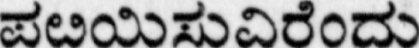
ಪೞಯಿಸುವಿರೆಂದು
